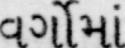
વર્ગોમાં
